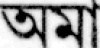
অমা
